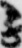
કે
